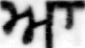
ਆ
